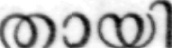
തായി
